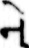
ને
